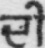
ਦੀ
